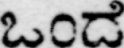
ಒಂದೆ
